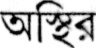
অস্থির
